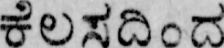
ಕೆಲಸದಿಂದ
